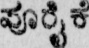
ಪೂರೈಕೆ
